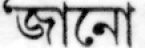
'জানো
